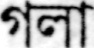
গলা
